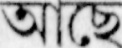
আছে
